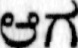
ಆಗ
